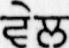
ਵੇਲ
